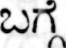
ಬಗ್ಗೆ
